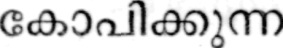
കോപിക്കുന്ന
